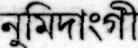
নুমিদাংগী
